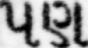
પણ
